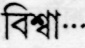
বিশ্বা...
